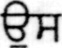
ਉਸ
